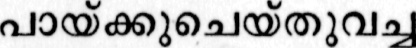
പായ്ക്കുചെയ്തുവച്ച
